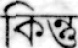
কিন্তু
